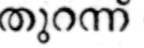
തുറന്ന്
